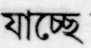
যাচ্ছে
